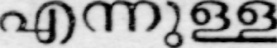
എന്നുള്ള
